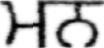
ਮਨ
